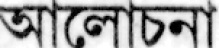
আলোচনা
